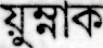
য়ুম্নাক
